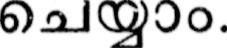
ചെയ്യാം.
